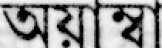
অয়াম্বা
